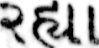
રહ્યા
